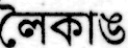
লৈকাঙ
